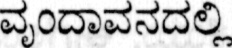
ವೃಂದಾವನದಲ್ಲಿ
